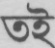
তই
